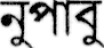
নুপাবু
